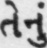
તેનું
